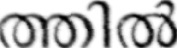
ത്തില്‍
